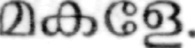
മകളേ.
